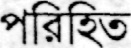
পরিহিত
